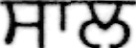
ਸਾਲ
